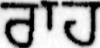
ਰਾਹ
